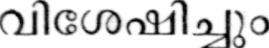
വിശേഷിച്ചും
